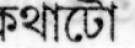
কথাটো
